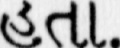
હતા.
